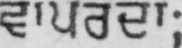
ਵਾਪਰਦਾ;
